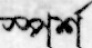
স্পর্শ
